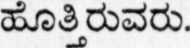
ಹೊತ್ತಿರುವರು.
